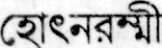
হোৎনরম্মী
